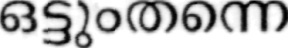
ഒട്ടുംതന്നെ
